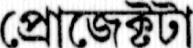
প্রোজেক্টটা
